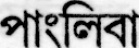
পাংলিবা
